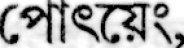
পোৎয়েং,
